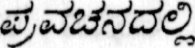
ಪ್ರವಚನದಲ್ಲಿ
